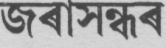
জৰাসন্ধৰ
